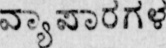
ವ್ಯಾಪಾರಗಳ
